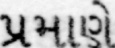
પ્રમાણે
